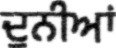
ਦੁਨੀਆਂ
